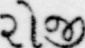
રોજી
